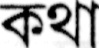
কথা
